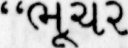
"ભૂચર
